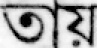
তায়
